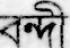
বন্দী
